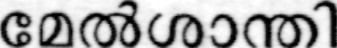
മേല്‍ശാന്തി
